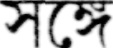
সঙ্গে
